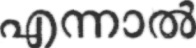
എന്നാല്‍
